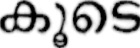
കൂടെ
